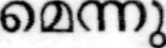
മെന്നു
